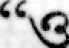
“ও
